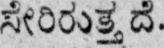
ಸೇರಿರುತ್ತದೆ.
